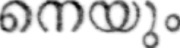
നെയും
